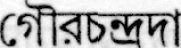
গৌরচন্দ্রদা
